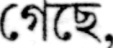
গেছে,
